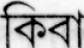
কিবা
